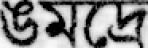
ঙমদ্রে
